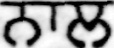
ਨਾਲ
